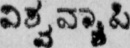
ವಿಶ್ವವ್ಯಾಪಿ
